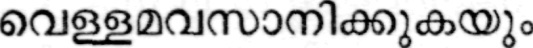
വെള്ളമവസാനിക്കുകയും
